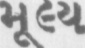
મૂલ્ય
